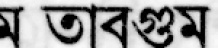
হকচাংনগা
